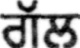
ਗੱਲ
